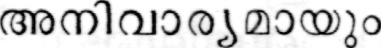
അനിവാര്യമായും
